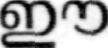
ഈ
